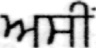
ਅਸੀਂ
